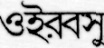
ওইরবসু
